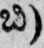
ಬಿ)
